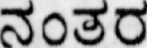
ನಂತರ
